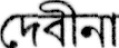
দেবীনা
